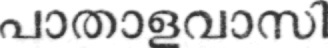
പാതാളവാസി
